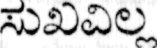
ಸುಖವಿಲ್ಲ
